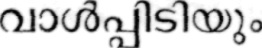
വാള്‍പ്പിടിയും
